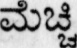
ಮೆಚ್ಚಿ
